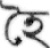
হৈ
